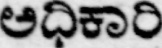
ಅಧಿಕಾರಿ
